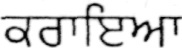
ਕਰਾਇਆ
